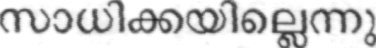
സാധിക്കയില്ലെന്നു
